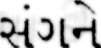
સંગન
